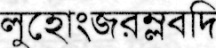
লুহোংজরম্লবদি
